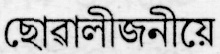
ছোৱালীজনীয়ে
